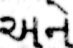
અને
